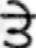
ਤੇ
